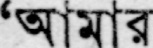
‘আমার
